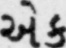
એક
